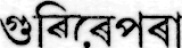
গুৰিৰেপৰা
